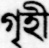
গৃহী
